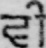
ਵੀ
